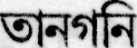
তানগনি
